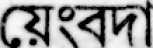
য়েংবদা
